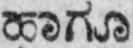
ಹಾಗೂ
